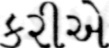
કરીએ
